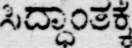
ಸಿದ್ಧಾಂತಕ್ಕೆ
